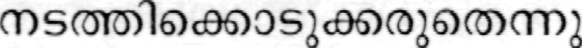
നടത്തിക്കൊടുക്കരുതെന്നു
